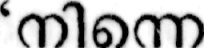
'നിന്നെ
